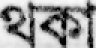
থকা
